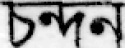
চন্দন
